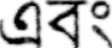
এবং
